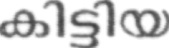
കിട്ടിയ
